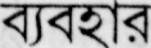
ব্যবহার
